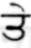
ਤੇ
